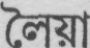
লৈয়া
